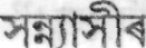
সন্ন্যাসীৰ
